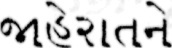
જાહેરાતને
